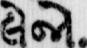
લેજો.
